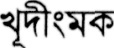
খূদীংমক
